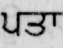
ਪਤਾ
